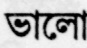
ভালো
